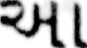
આ
